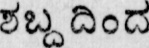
ಶಬ್ದದಿಂದ
